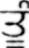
ਤੂੰ
